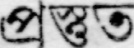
প্রস্তুত
